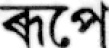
ৰূপে
